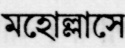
মহোল্লাসে
